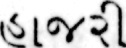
હાજરી
